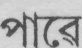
পাৱে
